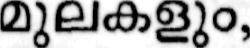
മുലകളും,
